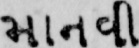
માનવી
